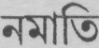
নমাতি
